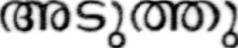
അടുത്തു
